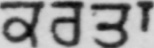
ਕਰਤਾ
